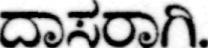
ದಾಸರಾಗಿ.
